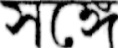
সঙ্গে
